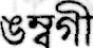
ঙম্বগী
